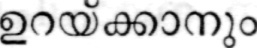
ഉറയ്ക്കാനും
